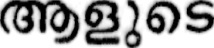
ആളുടെ
